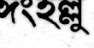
ঈংহল্লু
